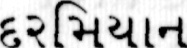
દરમિયાન
